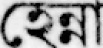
হেন্না
